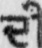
ਦੀ
